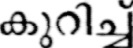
കുറിച്ച്
